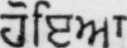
ਹੋਇਆ
